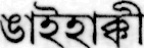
ঙাইহাক্কী
